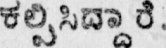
ಕಲ್ಪಿಸಿದ್ದಾರೆ.
